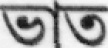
ভাত
